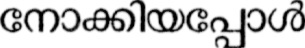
നോക്കിയപ്പോള്‍
